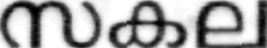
സകല
